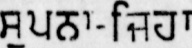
ਸੁਪਨਾ-ਜਿਹਾ
